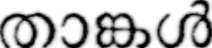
താങ്കള്‍
